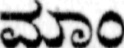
ಮಾಂ
